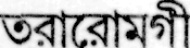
তরারোমগী
